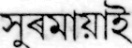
সুৰমায়াই
